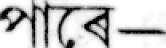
পাৰে-
